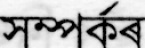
সম্পর্কৰ
